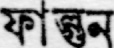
ফাল্গুন
